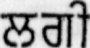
ਲਗੀ
